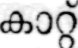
കാറ്റ്
